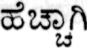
ಹೆಚ್ಚಾಗಿ
